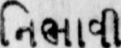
નિભાવી
